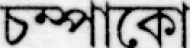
চম্পাকো
